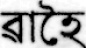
ৱাহৈ
